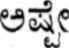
ಅಷ್ಟೇ
